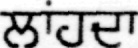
ਲਾਂਹਦਾ
